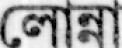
লোন্না
